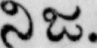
ನಿಜ.
